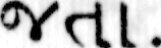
જતા.
